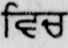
ਵਿਚ
